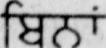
ਬਿਨਾਂ
